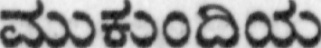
ಮುಕುಂದಿಯ
